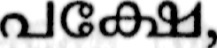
പക്ഷേ,
